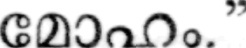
മോഹം.''
